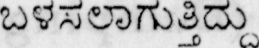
ಬಳಸಲಾಗುತ್ತಿದ್ದು
